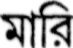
মারি
